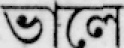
ভালে
